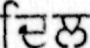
ਦਿਲ
